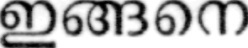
ഇങ്ങനെ
